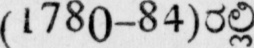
(1780-84)ರಲ್ಲಿ
